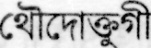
থৌদোক্তুগী
